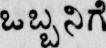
ಒಬ್ಬನಿಗೆ
